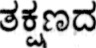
ತಕ್ಷಣದ
